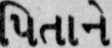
પિતાને
